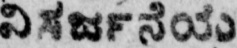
ವಿಸರ್ಜನೆಯ
